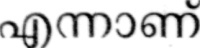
എന്നാണ്
